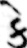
કે
